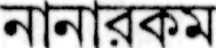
নানারকম
